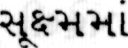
સૂક્ષ્મમાં
